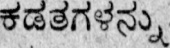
ಕಡತಗಳನ್ನು
